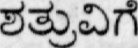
ಶತ್ರುವಿಗೆ
